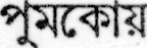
পুমকোয়
